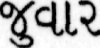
જુવાર
